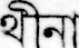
থীনা
